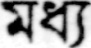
মধ্য
